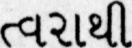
ત્વરાથી
